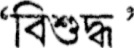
'বিশুদ্ধ'
